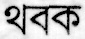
থবক
